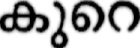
കുറെ
